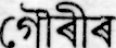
গৌৰীৰ
